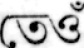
তেওঁ
